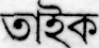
তাইক
